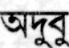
অদুবু
